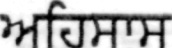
ਅਹਿਸਾਸ
